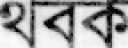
থবক
